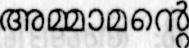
അമ്മാമന്റെ
